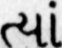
ત્યાં
